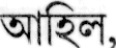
আহিল,
